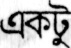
একটু
